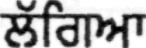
ਲੱਗਿਆ
